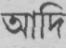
আদি
